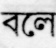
বলে
